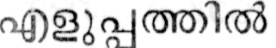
എളുപ്പത്തില്‍
